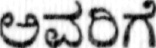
ಅವರಿಗೆ
